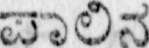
ಪಾಲಿನ
